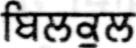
ਬਿਲਕੁਲ
